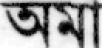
অমা
